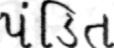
પંડિત
